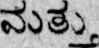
ಮತ್ತು
